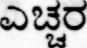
ಎಚ್ಚರ
